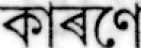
কাৰণে
